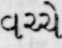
વચ્ચે
